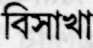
বিসাখা
